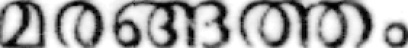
മരങ്ങത്തം
